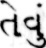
તેવું
